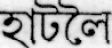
হাটলৈ
